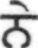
ਨੇ
